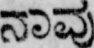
ನಾವು
